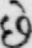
છે
